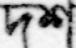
দশ
